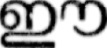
ഈ
